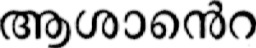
ആശാന്റെ
